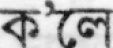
ক'লে
